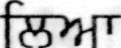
ਲਿਆ
